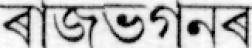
ৰাজভগনৰ
